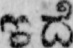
ಇದೆ
